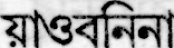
য়াওবনিনা
